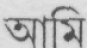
আমি
